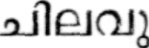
ചിലവു
